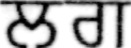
ਲਗ
